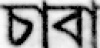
চাবা
